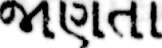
જાણતા
